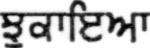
ਝੁਕਾਇਆ
